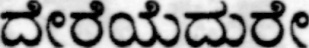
ದೇರೆಯೆದುರೇ
